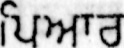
ਪਿਆਰ
